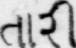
તારી
